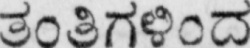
ತಂತಿಗಳಿಂದ
